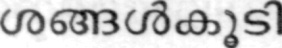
ശങ്ങള്‍കൂടി
